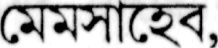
মেমসাহেব,
